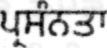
ਪ੍ਰਸੰਨਤਾ
